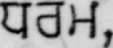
ਧਰਮ,
